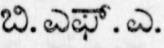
ಬಿ.ಎಫ್.ಎ.
